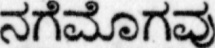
ನಗೆಮೊಗವು
